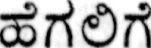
ಹೆಗಲಿಗೆ
